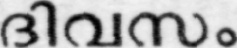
ദിവസം
